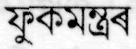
ফুকমন্ত্রৰ
